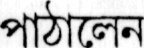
পাঠালেন
